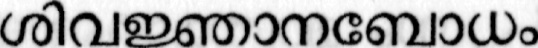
ശിവജ്ഞാനബോധം
